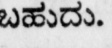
ಬಹುದು.
